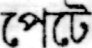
পেটে
